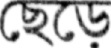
ছেড়ে
